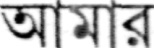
আমার
